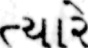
ત્યારે
